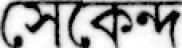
সেকেন্দ
